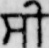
ਸੀ
